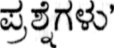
ಪ್ರಶ್ನೆಗಳು'
